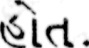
હોત.
